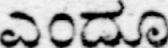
ಎಂದೂ
